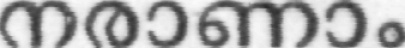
നരാണാം
